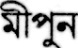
মীপুন
